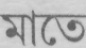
মাতে
